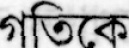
গতিকে
